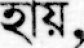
হায়,
